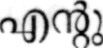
എന്റു
